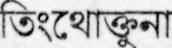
তিংথোক্তুনা
